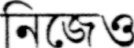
নিজেও
